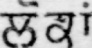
ਲੋਕਾਂ
